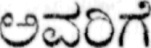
ಅವರಿಗೆ
